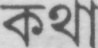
কথা
